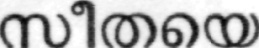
സീതയെ
